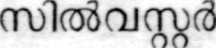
സില്‍വസ്റ്റര്‍
